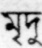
মৃদু
